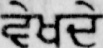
ਵੇਖਦੇ
